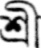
শ্রী
